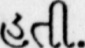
હતી.
